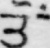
ਤੋਂ
